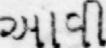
આવી
